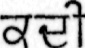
ਕਦੀ
